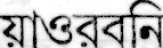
য়াওরবনি
